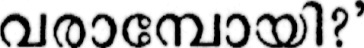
വരാമ്പോയി?’
